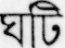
ঘটি
